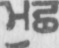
ਮੁਛ
